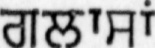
ਗਲਾਸਾਂ
